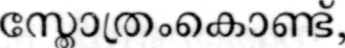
സ്തോത്രംകൊണ്ട്,
